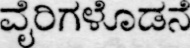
ವೈರಿಗಳೊಡನೆ
